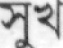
সুখ
